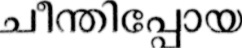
ചീന്തിപ്പോയ
